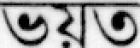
ভয়ত
